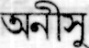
অনীসু
